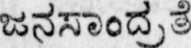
ಜನಸಾಂದ್ರತೆ
